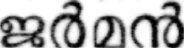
ജര്‍മന്‍
